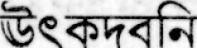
ঊৎকদবনি
